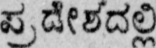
ಪ್ರದೇಶದಲ್ಲಿ
